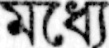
মধ্যে
